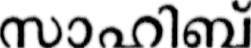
സാഹിബ്
